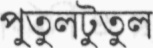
পুতুলটুতুল
